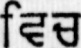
ਵਿਚ
